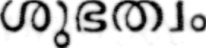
ശുഭത്വം
